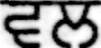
ਵਲ
